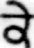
ਕੇ
